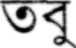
তবু
